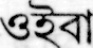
ওইবা
